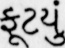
ફૂટ્યું
